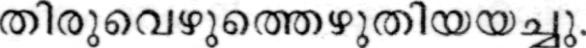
തിരുവെഴുത്തെഴുതിയയച്ചു.
